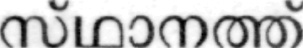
സ്ഥാനത്ത്
